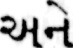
અને
